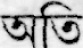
অতি
